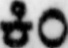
ಕಿಂ
